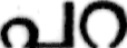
പറ
